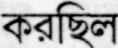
করছিল
